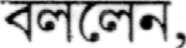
বললেন,
